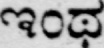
ಇಂಥ
